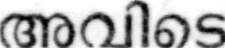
അവിടെ
